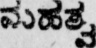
ಮಹತ್ವ
